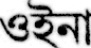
ওইনা
